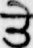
ਤੇ
